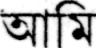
আমি
